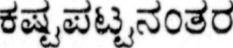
ಕಷ್ಟಪಟ್ಟನಂತರ
